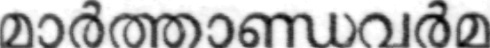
മാര്‍ത്താണ്ഡവര്‍മ
